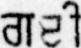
ਗਈ
